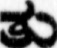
ತು
